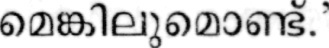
മെങ്കിലുമൊണ്ട്.'
